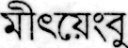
মীৎয়েংবু
